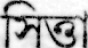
সিত্তা
